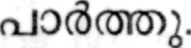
പാര്‍ത്തു.
